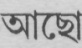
আছো
